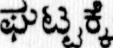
ಘಟ್ಟಕ್ಕೆ
